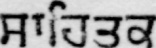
ਸਾਹਿਤਕ
